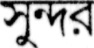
সুন্দর
